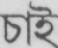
চাই
